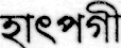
হাৎপগী
